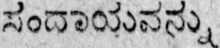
ಸಂದಾಯವನ್ನು
